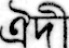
ঐদী
